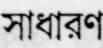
সাধারণ
